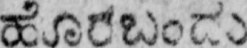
ಹೊರಬಂದು
